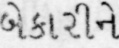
બેકારીને
